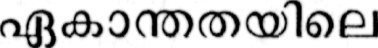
ഏകാന്തതയിലെ
